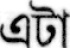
এটা
